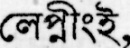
লেপ্নীংই,
